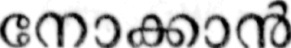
നോക്കാന്‍
